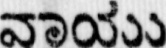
ವಾಯು
